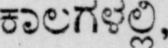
ಕಾಲಗಳಲ್ಲಿ,
